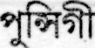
পুন্সিগী
